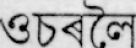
ওচৰলৈ
